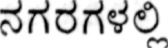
ನಗರಗಳಲ್ಲಿ
